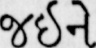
જઈને
